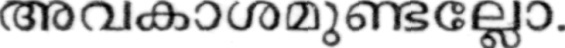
അവകാശമുണ്ടല്ലോ.
